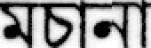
মচানা
